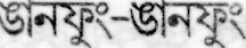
ঙানফুং-ঙানফুং
